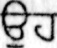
ਉਹ
